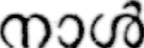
നാള്‍
